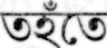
তহঁতে
